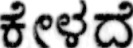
ಕೇಳದೆ
